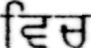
ਵਿਚ
